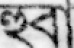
হুবা
